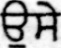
ਉਸੇ
